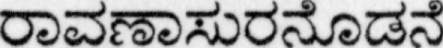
ರಾವಣಾಸುರನೊಡನೆ
